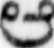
ಆ
